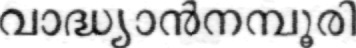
വാദ്ധ്യാന്‍നമ്പൂരി
